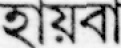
হায়বা
